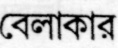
বেলাকার
